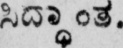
ಸಿದ್ಧಾಂತ.
